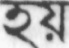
হয়
